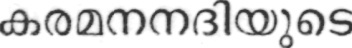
കരമനനദിയുടെ
